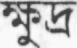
ক্ষুদ্র
